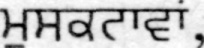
ਮੁਸਕਰਾਵਾਂ,
